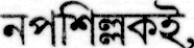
নপশিল্লকই,
